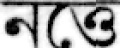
নত্তে
